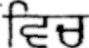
ਵਿਚ
